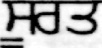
ਸੂਰਤ
